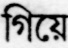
গিয়ে
